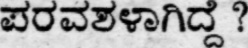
ಪರವಶಳಾಗಿದ್ದೆ?
